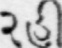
રહી
